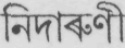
নিদাৰুণী
